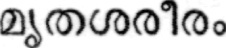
മൃതശരീരം
